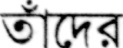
তাঁদের
